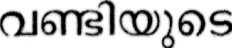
വണ്ടിയുടെ
